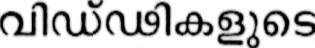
വിഡ്ഢികളുടെ
